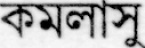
কমলাসু
